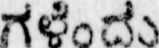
ಗಳೆಂದು
